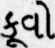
કૂવો
